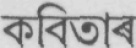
কবিতাৰ
